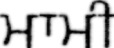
ਮਾਮੀ
